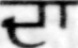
ਦਾ
